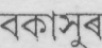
বকাসুৰ
